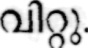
വിറ്റു.
